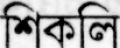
শিকলি
